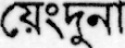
য়েংদুনা
